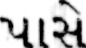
પાસે
